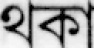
থকা
